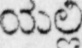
ಯಲ್ಲಿ
